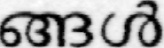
ങ്ങള്‍
